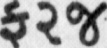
ફરજ
